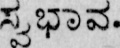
ಸ್ವಭಾವ.
